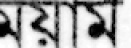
ময়াম
